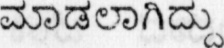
ಮಾಡಲಾಗಿದ್ದು
